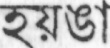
হয়ঙা
